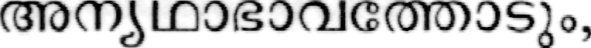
അന്യഥാഭാവത്തോടും,
